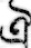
ঐ
